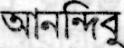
আনন্দিবু
